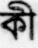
কী
